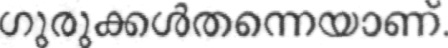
ഗുരുക്കള്‍തന്നെയാണ്.
